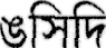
ঙসিদি
